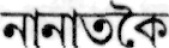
নানাতকৈ
